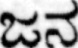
ಜನ
